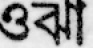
ওঝা
